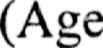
(Age
